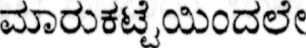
ಮಾರುಕಟ್ಟೆಯಿಂದಲೇ
